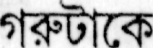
গরুটাকে
